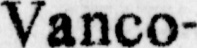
Vanco-
